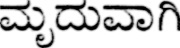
ಮೃದುವಾಗಿ
